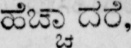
ಹೆಚ್ಚಾದರೆ,
